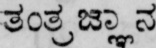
ತಂತ್ರಜ್ಞಾನ
